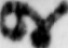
જ
